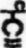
ਨੂੰ
